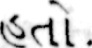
હતો.
